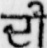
ਦੀ
